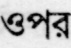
ওপর
